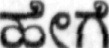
ಹೇಗೆ
